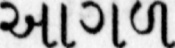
આગળ
